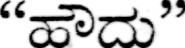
"ಹೌದು"
